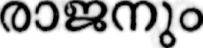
രാജനും
